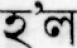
হ'ল
